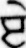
ਏ
